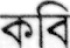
কবি
